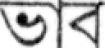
ভাব
